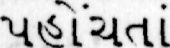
પહોંચતાં
